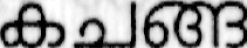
കചങ്ങ
